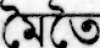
মৈতৈ
